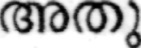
അതു
